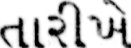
તારીખે
